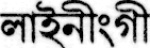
লাইনীংগী
